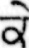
ਕੇ
